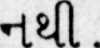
નથી.
